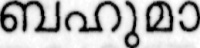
ബഹുമാ
